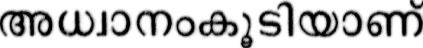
അധ്വാനംകൂടിയാണ്
